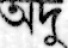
অদু
